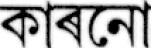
কাৰনো
